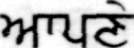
ਆਪਣੇ
